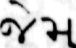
જેમ
